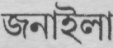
জনাইলা
